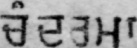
ਚੰਦਰਮਾ
